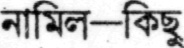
নামিল—কিছু
